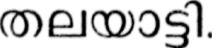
തലയാട്ടി.
